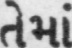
તેમાં
